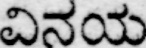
ವಿನಯ
